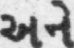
અને
